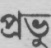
প্ৰভু
